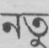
নতু
